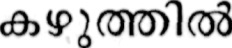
കഴുത്തില്‍
